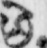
છે.
